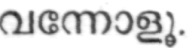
വന്നോളൂ.
